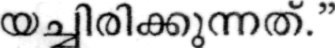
യച്ചിരിക്കുന്നത്."
